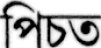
পিচত
